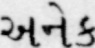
અનેક
